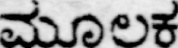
ಮೂಲಕ
